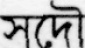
সদৌ
